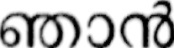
ഞാന്‍
